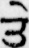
ਤੇ
